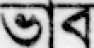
ভাব
